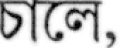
চালে,
